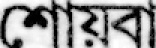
শোয়বা
